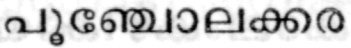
പൂഞ്ചോലക്കര
